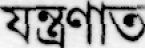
যন্ত্রণাত
